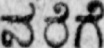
ವರೆಗೆ
